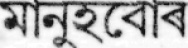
মানুহবোৰ
